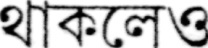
থাকলেও
